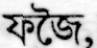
ফজৈ,
